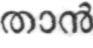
താന്‍
